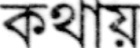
কথায়
